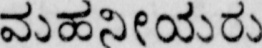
ಮಹನೀಯರು
